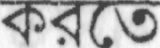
করতে
